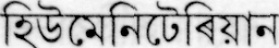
হিউমেনিটেৰিয়ান
